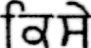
ਕਿਸੇ
